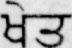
ਖੇਤ
